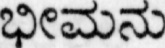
ಭೀಮನು
